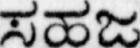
ಸಹಜ
